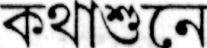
কথাশুনে
